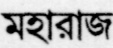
মহারাজ
